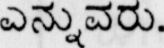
ಎನ್ನುವರು.
